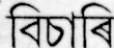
বিচাৰি
